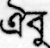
ঐবু
